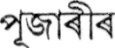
পূজাৰীৰ
